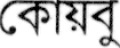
কোয়বু
